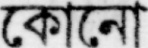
কোনো
